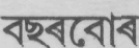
বছৰবোৰ
